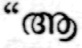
“ആ
